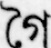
গৈ
